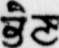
ਭੈਣ
